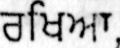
ਰਖਿਆ,
